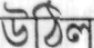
উঠিল
